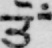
ਤੋਂ
